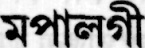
মপালগী
